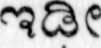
ಇಡೀ
